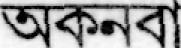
অকনবা
